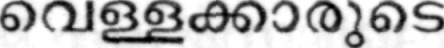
വെള്ളക്കാരുടെ
